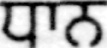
ਧਾਨ
